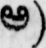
ಅ)
